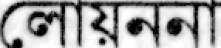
লোয়ননা
